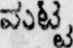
ಮಟ್ಟ
